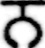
ਨ
